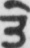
ਤੇ
